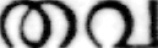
തവ
